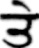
ਤੇ
